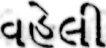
વહેલી
